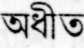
অধীত
